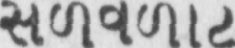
સળવળાટ
